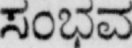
ಸಂಭವ
